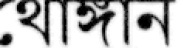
থোঙ্গান
